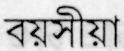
বয়সীয়া
